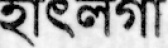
হাৎলগা
